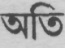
অতি
